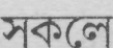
সকলে
